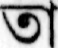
তা
